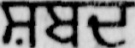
ਸ਼ਬਦ
